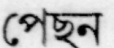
পেছন
